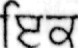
ਇਕ
